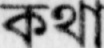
কথা
